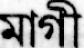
মাগী
